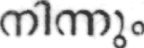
നിന്നും
